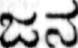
ಜನ
